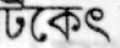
টিকেৎ
